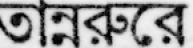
তান্নরুরে
